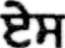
ਏਸ
